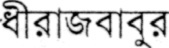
ধীরাজবাবুর
